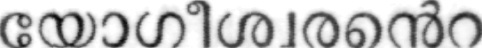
യോഗീശ്വരന്റെ
